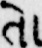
તો
